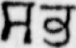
ਸਭ
